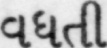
વધતી
